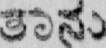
ತಾನು
